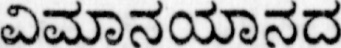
ವಿಮಾನಯಾನದ
